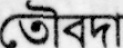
তৌবদা
